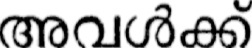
അവള്‍ക്ക്
